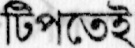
টিপতেই
